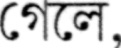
গেলে,
